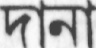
দানা
